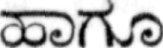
ಹಾಗೂ
